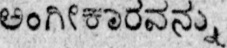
ಅಂಗೀಕಾರವನ್ನು
